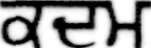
ਕਦਮ
